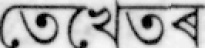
তেখেতৰ
